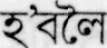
হ'বলৈ
